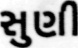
સુણી
